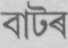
বাটৰ
